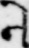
ને
